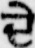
ਦੇ
